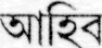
আহিব
